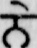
ਨੇ
